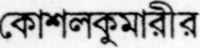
কোশলকুমারীর
